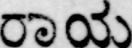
ರಾಯ
